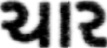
ચાર
